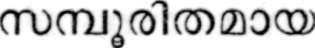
സമ്പൂരിതമായ
